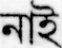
নাই
